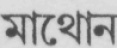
মাথোন
